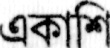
একাশি
